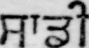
ਸਾਡੀ
